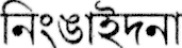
নিংঙাইদনা
